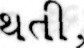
થતી,
